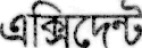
এক্সিদেন্ট
